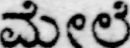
ಮೇಲೆ
